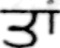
ਤਾਂ
